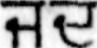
ਜਦ
